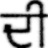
ਦੀ
